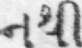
નથી
